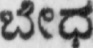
ಭೇಧ
